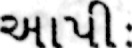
આપીઃ
